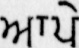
ਆਪੇ
